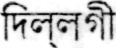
দিল্‌লগী
